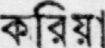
করিয়া
